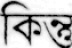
কিন্তু
